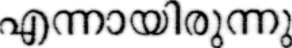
എന്നായിരുന്നു
